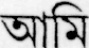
আমি
